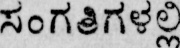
ಸಂಗತಿಗಳಲ್ಲಿ
